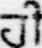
ਹੀ
